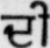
ਦੀ
